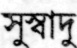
সুস্বাদু
